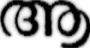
ആ
